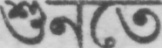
শুনতে
